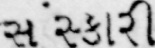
સંસ્કારી
